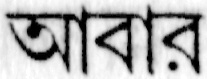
আবার
